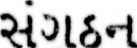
સંગઠન
